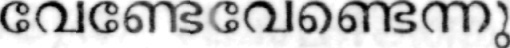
വേണ്ടേവേണ്ടെന്നു
